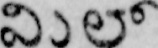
ಮಿಲ್
